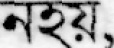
নহয়,
